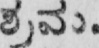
ಶ್ರಮ.
